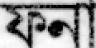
ফনা
